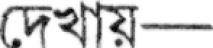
দেখায়-
